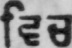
ਵਿਚ
